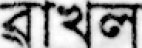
ৱাখল
